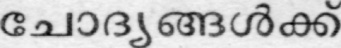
ചോദ്യങ്ങള്‍ക്ക്
